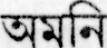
অমনি
